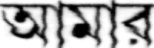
আমার
